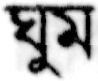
ঘুম
